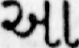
આ
